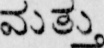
ಮತ್ತು
